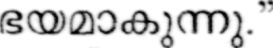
ഭയമാകുന്നു.”
